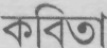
কবিতা
